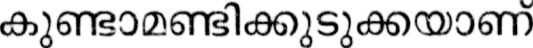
കുണ്ടാമണ്ടിക്കുടുക്കയാണ്
